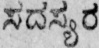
ಸದಸ್ಯರ
